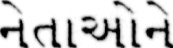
નેતાઓને
